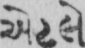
એટલે
